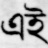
এই
